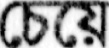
চেয়ে
